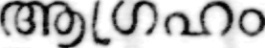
ആഗ്രഹം
